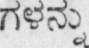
ಗಳನ್ನು
